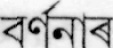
বর্ণনাৰ
